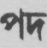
পদ
